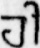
ਹੀ
